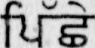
ਪਿੱਛੇ
